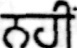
ਨਹੀਂ
